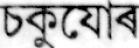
চকুযোৰ
